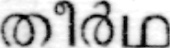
തീര്‍ഥ
